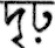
দৃঢ়
